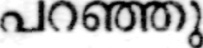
പറഞ്ഞു
